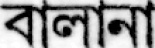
বালানা
